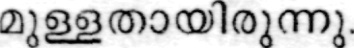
മുള്ളതായിരുന്നു.
